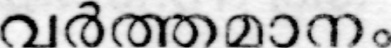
വര്‍ത്തമാനം
